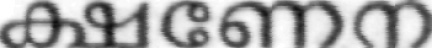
ക്ഷണേന
